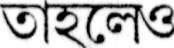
তাহলেও
